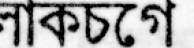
লাকচগে
